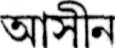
আসীন
